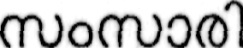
സംസാരി
